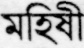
মহিষী
